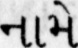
નામે
